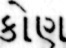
કોણ
